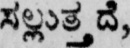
ಸಲ್ಲುತ್ತದೆ,
